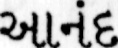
આનંદ
